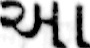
આ
